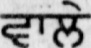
ਵਾਲੇ
